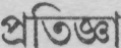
প্ৰতিজ্ঞা
